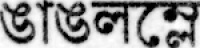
ঙাঙলম্লে
